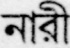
নারী
